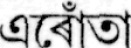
এৰোঁতা
